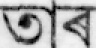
তাৰ
